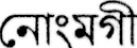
নোংমগী
